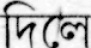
দিলে
